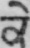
ਕੇ
